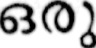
ഒരു
